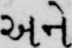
અને
